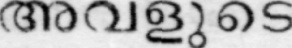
അവളുടെ
